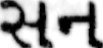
સન
